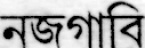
নজগাবি
